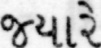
જ્યારે
